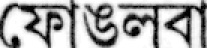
ফোঙলবা
